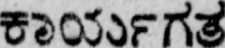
ಕಾರ್ಯಗತ
